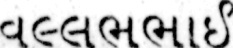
વલ્લભભાઈ
